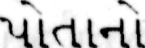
પોતાનો
